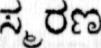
ಸ್ಮರಣ
